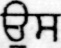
ਉਸ
